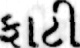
ફાટી
